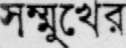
সম্মুখের
